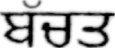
ਬੱਚਤ
